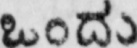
ಒಂದು
